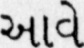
આવે
